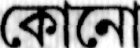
কোনো
